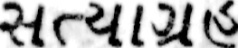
સત્યાગ્રહ
